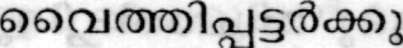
വൈത്തിപ്പട്ടര്‍ക്കു
